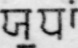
ਯੁਧਾਂ
